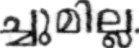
ച്ചുമില്ല.
